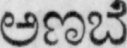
ಅಣಬೆ
